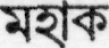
মহাক
